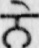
ਨੇ
